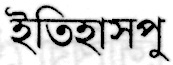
ইতিহাসপু
